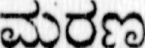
ಮರಣ
